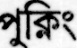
পুক্নিং
